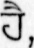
ਹੈ,
